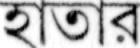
হাতার
